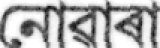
নোৱাৰা
